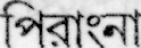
পিরাংনা
